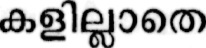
കളില്ലാതെ
